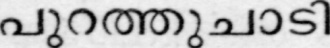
പുറത്തുചാടി
